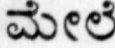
ಮೇಲೆ
